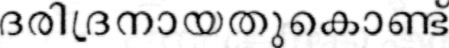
ദരിദ്രനായതുകൊണ്ട്
